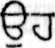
ਉਹ
